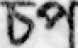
চপ
